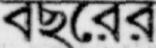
বছরের
